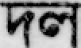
দল
